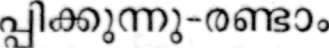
പ്പിക്കുന്നു-രണ്ടാം
